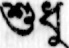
শুধু
